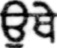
ਉਥੇ
